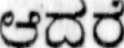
ಆದರೆ
